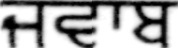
ਜਵਾਬ
